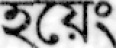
হয়েং
